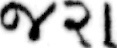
જરા
